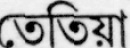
তেতিয়া
